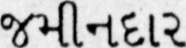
જમીનદાર
